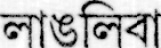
লাঙলিবা
